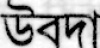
উবদা
